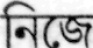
নিজে
